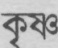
কৃষ্ণ
